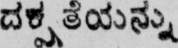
ದಕ್ಷತೆಯನ್ನು
